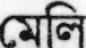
মেলি
